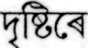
দৃষ্টিৰে
